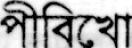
পীবিখো
